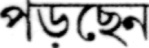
পড়ছেন
